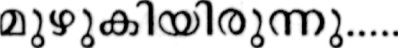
മുഴുകിയിരുന്നു...
